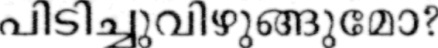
പിടിച്ചുവിഴുങ്ങുമോ?
